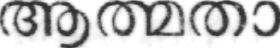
ആത്മതാ
